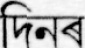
দিনৰ
